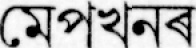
মেপখনৰ
